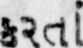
કરતાં
